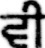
ਵੀ
